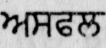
ਅਸਫਲ
